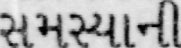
સમસ્યાની
